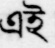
এই
